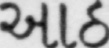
આઠ
